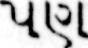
પણ
